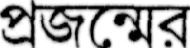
প্রজন্মের
